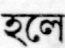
হলে
